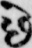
છે
